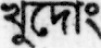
খুদোং
